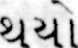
થયો
